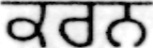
ਕਰਨ
